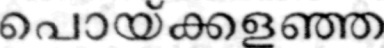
പൊയ്ക്കളഞ്ഞ
